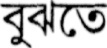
বুঝতে
